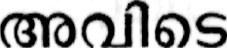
അവിടെ
